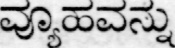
ವ್ಯೂಹವನ್ನು
